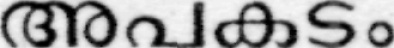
അപകടം
